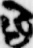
છે
